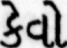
કેવો
